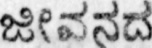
ಜೀವನದ
